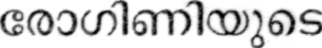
രോഗിണിയുടെ
